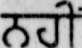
ਨਹੀਂ
